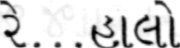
રે...હાલો
